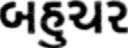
બહુચર
